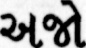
અજો
